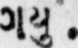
ગયું.
